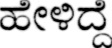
ಹೇಳಿದ್ದೆ
